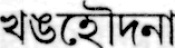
খঙহৌদনা
